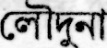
লৌদুনা
